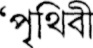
'পৃথিবী
